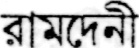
রামদেনী
